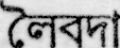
লৈবদা
